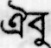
ঐবু
